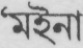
'মইনা
